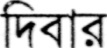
দিবার
